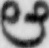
ಆ
